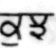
ਕੁਝ
